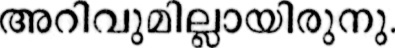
അറിവുമില്ലായിരുനു.
